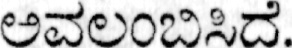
ಅವಲಂಬಿಸಿದೆ.
